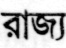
রাজ্য
